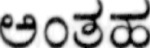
ಅಂತಹ
